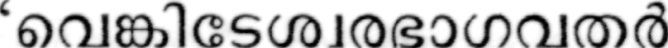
'വെങ്കിടേശ്വരഭാഗവതര്‍
